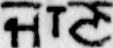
ਜਾਣ
